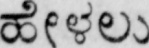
ಹೇಳಲು
